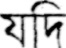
যদি
